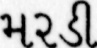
મરડી
